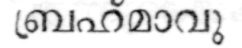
ബ്രഹ്മാവു
